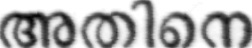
അതിനെ
